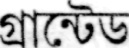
গ্রান্টেড
